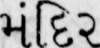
મંદિર
